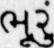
ભૂરું
